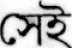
সেই
